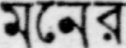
মনের
